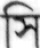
সি
